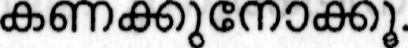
കണക്കുനോക്കൂ.
